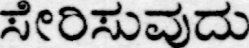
ಸೇರಿಸುವುದು
